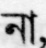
না,
